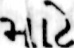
માટે
